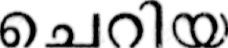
ചെറിയ
